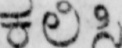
ಕಲಿಸಿ
